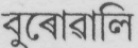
বুৰোৱালি
